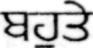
ਬਹੁਤੇ
